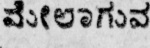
ಮೇಲಾಗುವ
